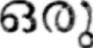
ഒരു
